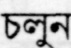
চলুন
